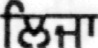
ਲਿਜਾ
